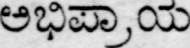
ಅಭಿಪ್ರಾಯ
